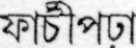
ফাৰ্চীপঢ়া
